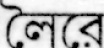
লৈরে
